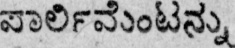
ಪಾರ್ಲಿಮೆಂಟನ್ನು
